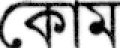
কোম
